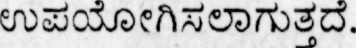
ಉಪಯೋಗಿಸಲಾಗುತ್ತದೆ.
